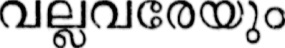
വല്ലവരേയും
